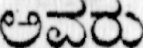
ಅವರು
